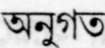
অনুগত
